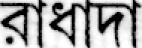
রাধাদা
